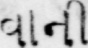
વાની
